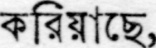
করিয়াছে,
